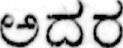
ಅದರ
